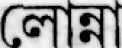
লোন্না
